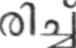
രിച്ച്
